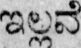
ಇಲ್ಲವೆ
